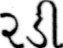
રડી
